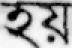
হয়
